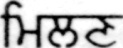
ਮਿਲਣ
